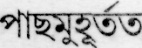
পাছমুহূর্তত
